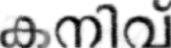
കനിവ്
